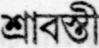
শ্রাবস্তী
